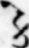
કે
